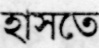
হাসতে
